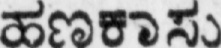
ಹಣಕಾಸು
